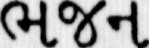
ભજન
